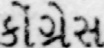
કોંગ્રેસ
